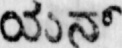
ಯನ್
